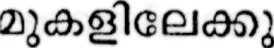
മുകളിലേക്കു
